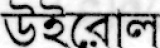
উইরোল
